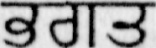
ਭਗਤ
